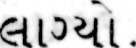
લાગ્યો.
